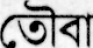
তৌবা
